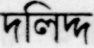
দলিদ্দ
